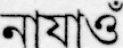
নাযাওঁ
